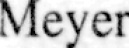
Meyer
